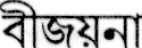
বীজয়না
